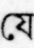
যে
